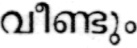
വീണ്ടും
